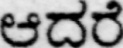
ಆದರೆ
